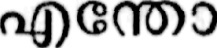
എന്തോ
